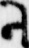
ને
